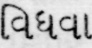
વિધવા
